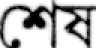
শেষ
